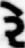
રે
